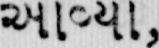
આવ્યા,
